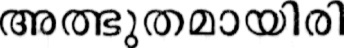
അത്ഭുതമായിരി
